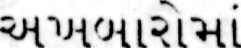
અખબારોમાં
